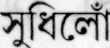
সুধিলোঁ
